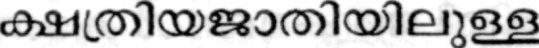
ക്ഷത്രിയജാതിയിലുള്ള
